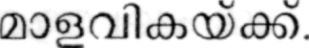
മാളവികയ്ക്ക്.
